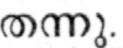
തന്നു.
